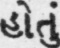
હોતું
